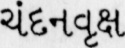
ચંદનવૃક્ષ
